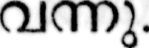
വന്നു.
